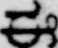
ಈ
